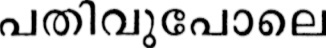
പതിവുപോലെ
